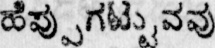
ಹೆಪ್ಪುಗಟ್ಟುವವು
